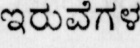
ಇರುವೆಗಳ
